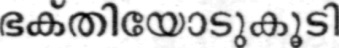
ഭക്തിയോടുകൂടി
